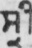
ਸ੍ਰੀ
